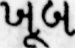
ખૂબ
